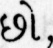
છો,
